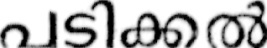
പടിക്കല്‍
